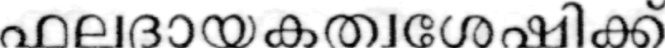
ഫലദായകത്വശേഷിക്ക്
